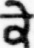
ਕੇ
